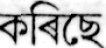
কৰিছে
